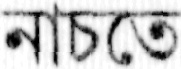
নাচতে
